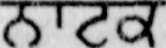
ਨਾਟਕ
